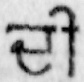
ਦੀ
